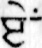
ਏਂ
